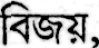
বিজয়,
